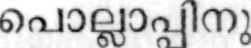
പൊല്ലാപ്പിനു
